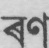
ৰণ
